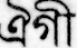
ঐগী
